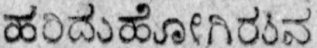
ಹರಿದುಹೋಗಿರುವ
